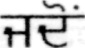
ਜਦੋਂ
